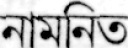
নামনিত
